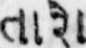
તારો
